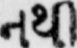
નથી
